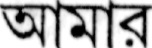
আমার
